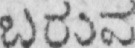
ಬರುವ
